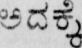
ಅದಕ್ಕೆ
